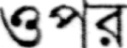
ওপর
